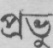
প্ৰভু
